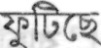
ফুটিছে
